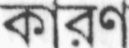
কারণ
